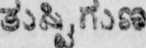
ತುಷ್ಟಿಗುಣ
